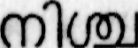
നിശ്ച
